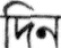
দিন
